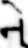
ને
